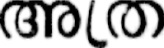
അത്ര
